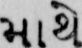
માથે
